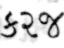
કરજ
